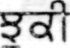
ਝੁਕੀ
